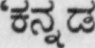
‘ಕನ್ನಡ
